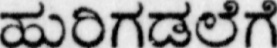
ಹುರುಗಡಲೆಗೆ
